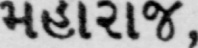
મહારાજ,
